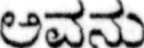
ಅವನು
